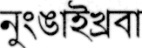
নুংঙাইখ্রবা
